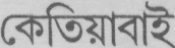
কেতিয়াবাই
